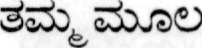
ತಮ್ಮಮೂಲ
